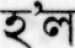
হ'ল
